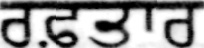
ਰਫ਼ਤਾਰ
